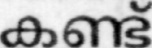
കണ്ട്
